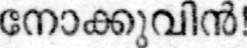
നോക്കുവിന്‍!
